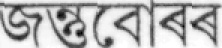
জন্তুবোৰৰ
